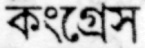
কংগ্রেস
